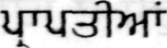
ਪ੍ਰਾਪਤੀਆਂ
